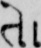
તો
